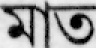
মাত
